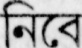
নিবে
